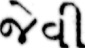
જેવી
